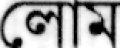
লোম
